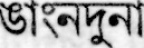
ঙাংনদুনা
